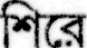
শিরে
